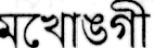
মখোঙগী
